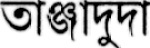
তাঞ্জাদুদা
